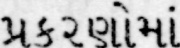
પ્રકરણોમાં
